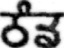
ਠੰਡ
